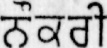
ਨੌਕਰੀ
